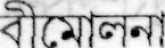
বীমোলনা
